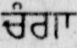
ਚੰਗਾ
